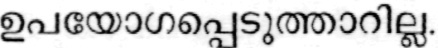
ഉപയോഗപ്പെടുത്താറില്ല.
